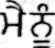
ਮੈਨੂੰ
